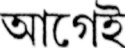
আগেই
